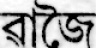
ৱাজৈ
